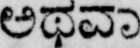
ಅಥವಾ
